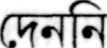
দেননি
